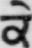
ਕੇ
